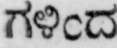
ಗಳಿಂದ
